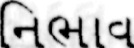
નિભાવ
